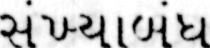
સંખ્યાબંધ
